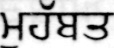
ਮੁਹੱਬਤ
